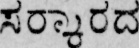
ಸರ್‍ಕಾರದ
